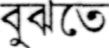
বুঝতে
